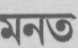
মনত
